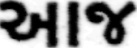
આજ
